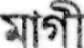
মাগী
